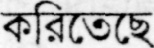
করিতেছে
